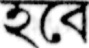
হবে
